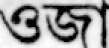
ওজা
